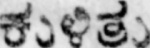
ಕುಳಿತು
